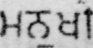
ਮਨੁਖੀ
